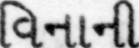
વિનાની
